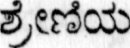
ಶ್ರೇಣಿಯ
